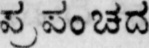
ಪ್ರಪಂಚದ
